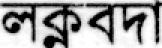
লক্নবদা
